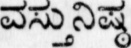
ವಸ್ತುನಿಷ್ಠ
